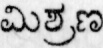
ಮಿಶ್ರಣ
